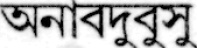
অনাবদুবুসু
